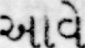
આવે
